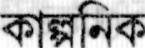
কাল্পনিক
